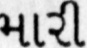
મારી
